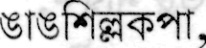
ঙাঙশিল্লকপা,
